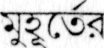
মুহূর্তের
